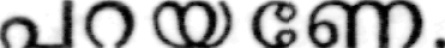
പറയണേ.
